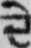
ਦੇ
